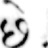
છે.
